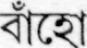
বাঁহো
